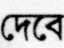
দেবে
